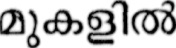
മുകളില്‍
